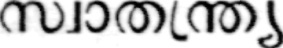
സ്വാതന്ത്ര്യ
